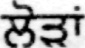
ਲੋੜਾਂ
